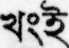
খংই
